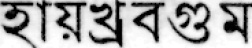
হায়খ্রবগুম
